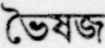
ভৈষজ
